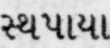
સ્થપાયા
